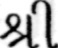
શ્રી
